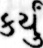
કર્યું
